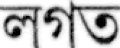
লগত
